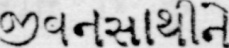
જીવનસાથીને
